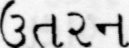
ઉતરન
